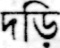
দড়ি
